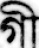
গী
